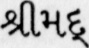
શ્રીમદ્
